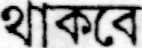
থাকবে
